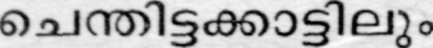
ചെന്തിട്ടക്കാട്ടിലും
